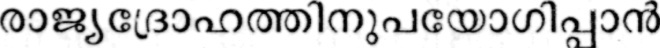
രാജ്യദ്രോഹത്തിനുപയോഗിപ്പാന്‍
